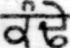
ਕੰਢੇ
